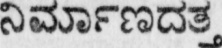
ನಿರ್ಮಾಣದತ್ತ
